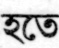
হতে
